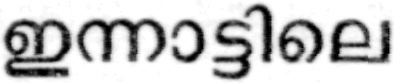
ഇന്നാട്ടിലെ
